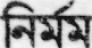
নিৰ্মম
